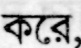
করে,
